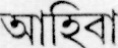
আহিবা
